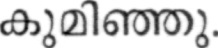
കുമിഞ്ഞു.
